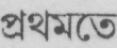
প্ৰথমতে
